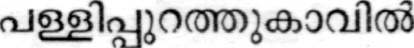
പള്ളിപ്പുറത്തുകാവില്‍
